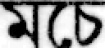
মচে
